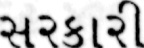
સરકારી
